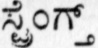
ಸ್ಟ್ರೆಂಗ್ತ್
